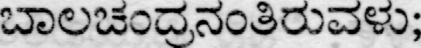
ಬಾಲಚಂದ್ರನಂತಿರುವಳು;
